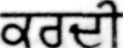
ਕਰਦੀ
